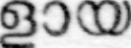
ളായ
